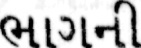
ભાગની
